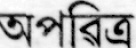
অপৱিত্র
